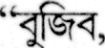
"বুজিব,
